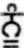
ਨੂੰ
